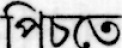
পিচতে
